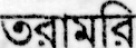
তরামরি
